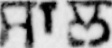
ਸਾਲ
